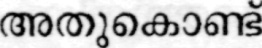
അതുകൊണ്ട്
